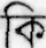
কি
